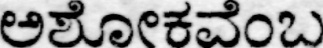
ಅಶೋಕವೆಂಬ
